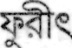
ফুরীৎ
